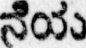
ನೆಯ
